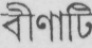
বীণাটি
